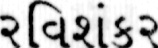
રવિશંકર
